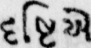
દષ્ટિએ
